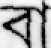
বা
